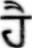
ਹੈ
